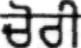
ਚੋਰੀ
